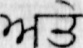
ਅਤੇ
